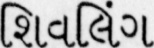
શિવલિંગ
